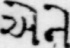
એને
